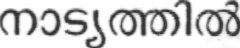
നാട്യത്തില്‍
